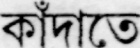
কাঁদাতে
